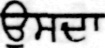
ਉਸਦਾ
